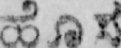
ಹೊಸ
